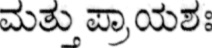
ಮತ್ತುಪ್ರಾಯಶಃ
